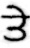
ਤੇ
